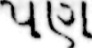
પણ
